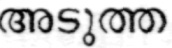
അടുത്ത
